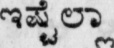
ಇಷ್ಟೆಲ್ಲಾ
